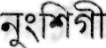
নুংশিগী
